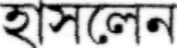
হাসলেন
